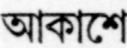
আকাশে
